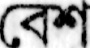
বেশ
